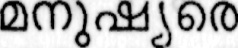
മനുഷ്യരെ
